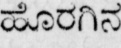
ಹೊರಗಿನ
